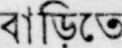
বাড়িতে
